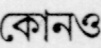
কোনও
